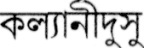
কল্যানীদুসু
